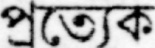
প্রত্যেক
